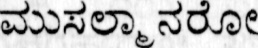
ಮುಸಲ್ಮಾನರೋ
